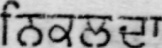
ਨਿਕਲਦਾ
